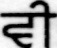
ਵੀ
